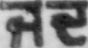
ਜਦ
